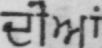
ਦੀਆਂ
